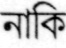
নাকি
